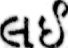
લઈ
